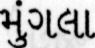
મુંગલા
